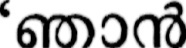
‘ഞാന്‍
